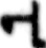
ન
